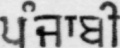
ਪੰਜਾਬੀ
